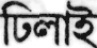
ঢিলাই
